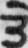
ਤੇ
